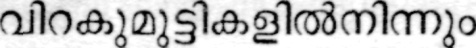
വിറകുമുട്ടികളില്‍നിന്നും
